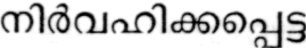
നിര്‍വഹിക്കപ്പെട്ട
